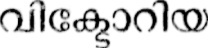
വിക്ടോറിയ
